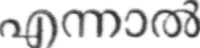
എന്നാല്‍
